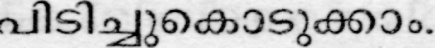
പിടിച്ചുകൊടുക്കാം.
